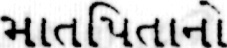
માતપિતાનો
